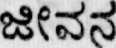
ಜೀವನ
